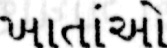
ખાતાંઓ
